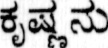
ಕೃಷ್ಣನು
